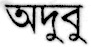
অদুবু
